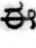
ಈ
